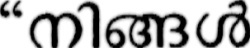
“നിങ്ങള്‍
